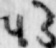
પડે
